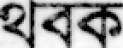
থবক
